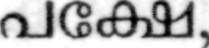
പക്ഷേ,
